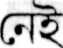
নেই
